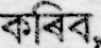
কৰিব,
